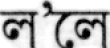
ল'লে
